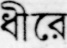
ধীরে
